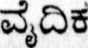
ವೈದಿಕ
